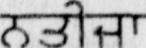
ਨਤੀਜਾ
